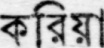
করিয়া
